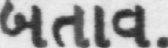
બતાવ.
